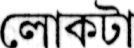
লোকটা
